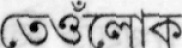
তেওঁলোক
